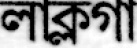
লাক্লগা
